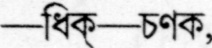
–ধিক্–চণক,
